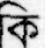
কি
